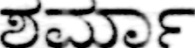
ಶರ್ಮಾ
